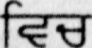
ਵਿਚ
